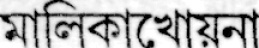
মালিকাখোয়না
